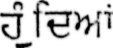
ਹੁੰਦਿਆਂ
